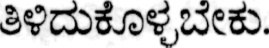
ತಿಳಿದುಕೊಳ್ಳಬೇಕು.
